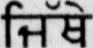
ਜਿੱਥੇ
